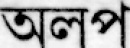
অলপ
